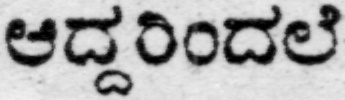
ಆದ್ದರಿಂದಲೆ
